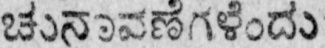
ಚುನಾವಣೆಗಳೆಂದು
